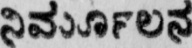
ನಿರ್ಮೂಲನ
